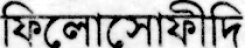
ফিলোসোফীদি
